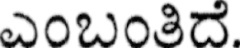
ಎಂಬಂತಿದೆ.
